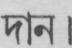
দান।
